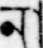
না
